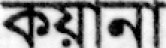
কয়ানা
